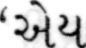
'એય
